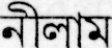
নীলাম
